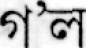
গ'ল
